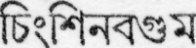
চিংশিনবগুম
